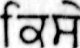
ਕਿਸੇ
